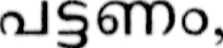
പട്ടണം,
